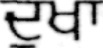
ਦੁਖਾ
